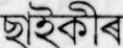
ছাইকীৰ
